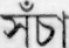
সঁচা
